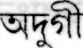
অদুগী
